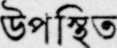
উপস্থিত
